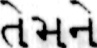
તેમને
